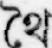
থৈ
